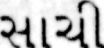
સાચી
